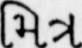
મિત્ર
